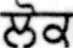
ਲੋਕ
